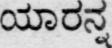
ಯಾರನ್ನ
